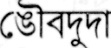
ঙৌবদুদা
